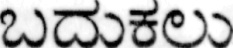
ಬದುಕಲು
